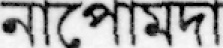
নাপোমদা
